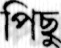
পিছু
